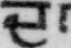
ਦਾ
